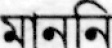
মাননি
